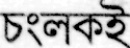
চংলকই
